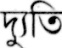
দ্যুতি
